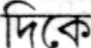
দিকে
